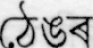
ঠেঙৰ
